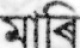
মাৰি
